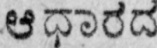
ಆಧಾರದ
